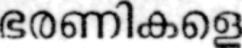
ഭരണികളെ
